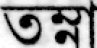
তম্না
